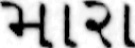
મારા
